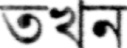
তখন
